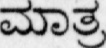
ಮಾತ್ರ
